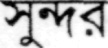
সুন্দর
